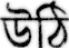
উঠি
